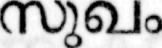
സുഖം
